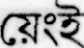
য়েংই
